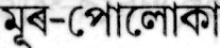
মূৰ-পোলোকা
